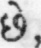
છે,
